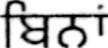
ਬਿਨਾਂ
